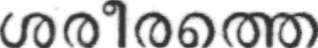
ശരീരത്തെ
